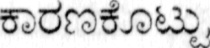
ಕಾರಣಕೊಟ್ಟು
